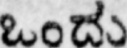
ಒಂದು
